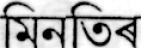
মিনতিৰ
